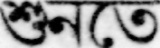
শুনতে
